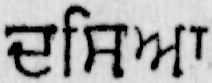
ਦਸਿਆ
